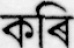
কৰি
